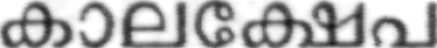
കാലക്ഷേപ
